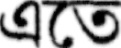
এতে
